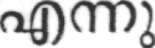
എന്നു
